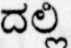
ದಲ್ಲಿ
